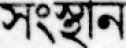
সংস্থান
